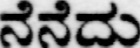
ನೆನೆದು
